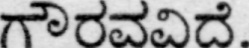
ಗೌರವವಿದೆ.
